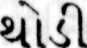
થોડી
